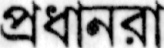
প্রধানরা
